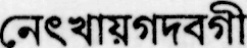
নেৎখায়গদবগী
